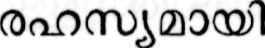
രഹസ്യമായി
